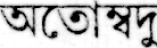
অতোম্বদু
